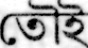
তৌই
